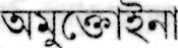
অমুক্তোইবা
